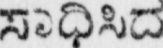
ಸಾಧಿಸಿದ
